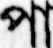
পা
